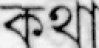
কথা
